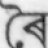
ৰৈ
